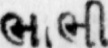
ભાભી
